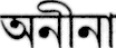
অনীনা
